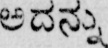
ಅದನ್ನು
